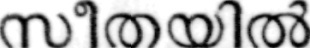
സീതയില്‍
